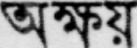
অক্ষয়
